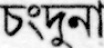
চংদুনা
